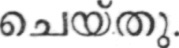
ചെയ്തു.
